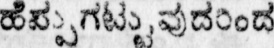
ಹೆಪ್ಪುಗಟ್ಟುವುದರಿಂದ
